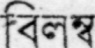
বিলম্ব
